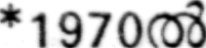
*1970ല്‍
